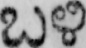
ಬಳಿ
